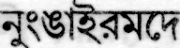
নুংঙাইরমদে
